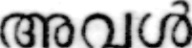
അവള്‍
